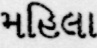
મહિલા
